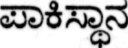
ಪಾಕಿಸ್ಥಾನ
